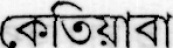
কেতিয়াবা
